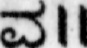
ವ||
